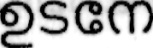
ഉടനേ
